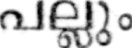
പല്ലും
